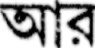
আর
